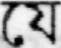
যে
